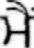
ਮੈਂ
